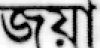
জয়া
